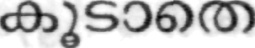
കൂടാതെ
